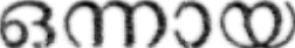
ഒന്നായ
